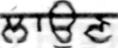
ਲਾਉਣ
